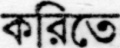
করিতে
